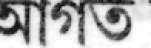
আগত
